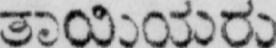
ತಾಯಿಯರು
